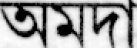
অমদা
